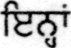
ਇਨ੍ਹਾਂ
